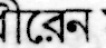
ধীরেন
